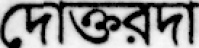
দোক্তরদা
